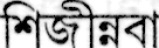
শিজীন্নবা
